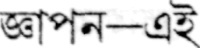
জ্ঞাপন–এই
